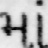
માં
